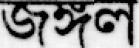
জঙ্গল
